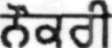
ਨੌਕਰੀ
